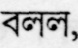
বলল,
